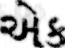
એક
